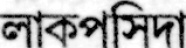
লাকপসিদা
